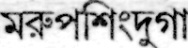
মরুপশিংদুগা
